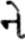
ને
